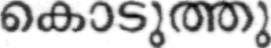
കൊടുത്തു
